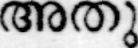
അതു
